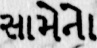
સામેનો
